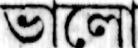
ভালো
